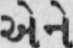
એને
